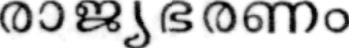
രാജ്യഭരണം
